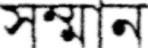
সম্মান
